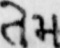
તેમ
